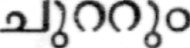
ചുററും
